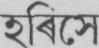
হৰিসে
